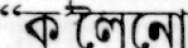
"ক'লৈনো
